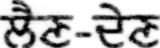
ਲੈਣ-ਦੇਣ
